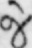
જે
